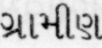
ગ્રામીણ
